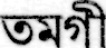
তমগী
